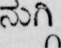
ನುಗ್ಗಿ
